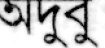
অদুবু
